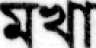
মখা
